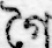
গৈ
